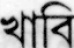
খাবি
